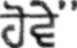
ਹੋਵੇ''
